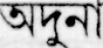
অদুনা
